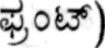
ಫ್ರಂಟ್)
